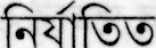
নির্যাতিত
